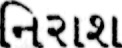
નિરાશ
